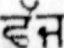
ਵੱਜ
